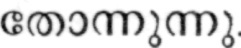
തോന്നുന്നു.
